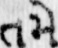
તમે
